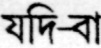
যদি-বা
